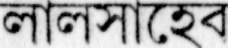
লালসাহেব
